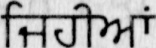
ਜਿਹੀਆਂ
